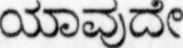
ಯಾವುದೇ
